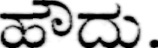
ಹೌದು.
